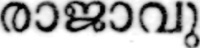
രാജാവു
